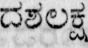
ದಶಲಕ್ಷ
